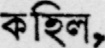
কহিল,
